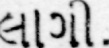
લાગી.
